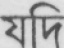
যদি
